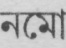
নমো
